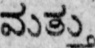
ಮತ್ತು
